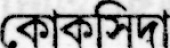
কোকসিদা
